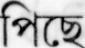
পিছে
